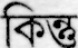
কিন্তু
